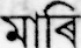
মাৰি
